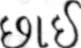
છાઈ
